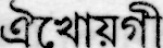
ঐখোয়গী
